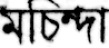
মচিন্দা
